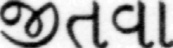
જીતવા
